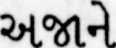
અજાને
